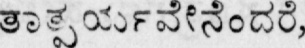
ತಾತ್ಪರ್ಯವೇನೆಂದರೆ,
